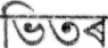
ভিতৰ
